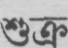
শুক্ৰ
